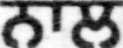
ਨਾਲ
